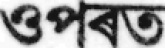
ওপৰত
